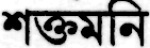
শক্তমনি
